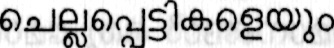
ചെല്ലപ്പെട്ടികളെയും
